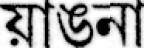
য়াঙনা
